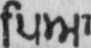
ਪਿਆ
